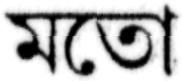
মতো
